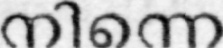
നിന്നെ
